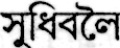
সুধিবলৈ
